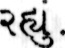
રહ્યું.
